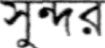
সুন্দর
